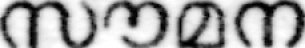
സൌമന
